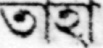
তাহা
